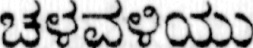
ಚಳವಳಿಯು
